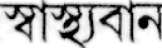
স্বাস্হ্যবান
